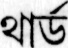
থার্ড
